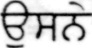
ਉਸਨੇ
